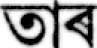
তাৰ
